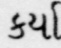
કર્યા
